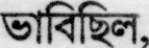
ভাবিছিল,
